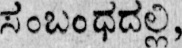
ಸಂಬಂಧದಲ್ಲಿ,
